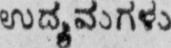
ಉದ್ಯಮಗಳು
